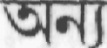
অন্য
